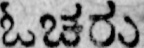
ಓಚರು
